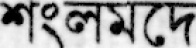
শংলমদে
